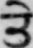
ਤੇ
